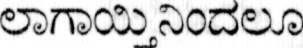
ಲಾಗಾಯ್ತಿನಿಂದಲೂ
